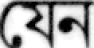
যেন
